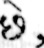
છે,
